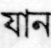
যান
